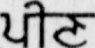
ਪੀਣ
